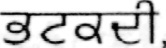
ਭਟਕਦੀ,
